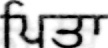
ਪਿਤਾ
